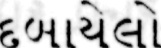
દબાયેલો
